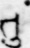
તું
